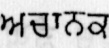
ਅਚਾਨਕ
